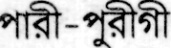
পারী-পুরীগী
